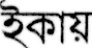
ইকায়
